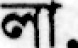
লা.
